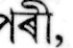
পৰী,
